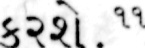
કરશે.૧૧
